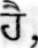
ਹੈ,
